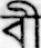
বী
